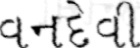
વનદેવી
